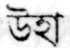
উহা
